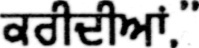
ਕਰੀਦੀਆਂ,''
